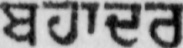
ਬਹਾਦਰ
